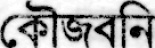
কৌজবনি
